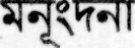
মনূংদনা
